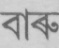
বাৰু
